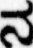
ನ
